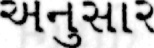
અનુસાર
